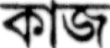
কাজ
